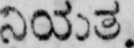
ನಿಯತ.
